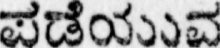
ಪಡೆಯುವ
